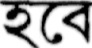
হবে
